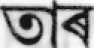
তাৰ
